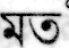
মত
